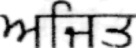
ਅਜਿਤ
